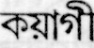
কয়াগী
